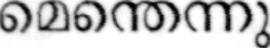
മെന്തെന്നു
